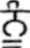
ਨੂੰ
